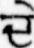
ਦੇ
